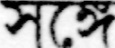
সঙ্গে
